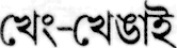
খেং-খেঙাই
